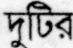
দুটির
